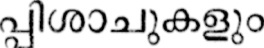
പ്പിശാചുകളും
